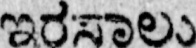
ಇರಸಾಲು
